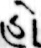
હો
